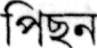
পিছন
